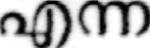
എന്ന
